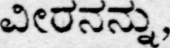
ವೀರನನ್ನು,
